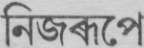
নিজৰূপে
